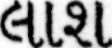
લાશ
